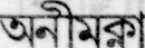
অনীমক্না
